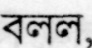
বলল,
